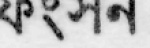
ফংসন
